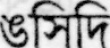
ঙসিদি
